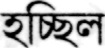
হচ্ছিল
